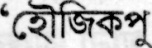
‘হৌজিকপু
